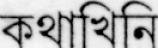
কথাখিনি
